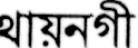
থায়নগী
